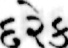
દરેક
